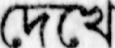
দেখে
